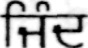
ਜਿੰਦ
